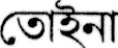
তোইনা
